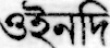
ওইনদি
